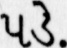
પડે.
